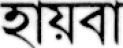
হায়বা
